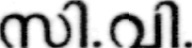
സി.വി.
